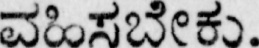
ವಹಿಸಬೇಕು.
